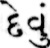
દેવું
